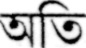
অতি
